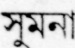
সুমনা
